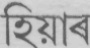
হিয়াৰ
